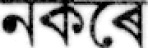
নকৰে
